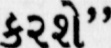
કરશે"
